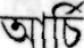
আৰ্চি
